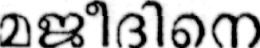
മജീദിനെ
